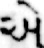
એ
